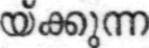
യ്ക്കുന്ന
